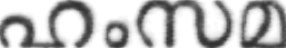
ഹംസമ
